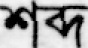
শব্দ
